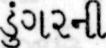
ડુંગરની
